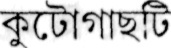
কুটোগাছটি
